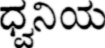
ಧ್ವನಿಯ
